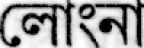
লোংনা
